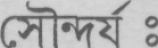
সৌন্দৰ্যঃ
